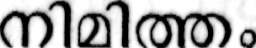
നിമിത്തം
